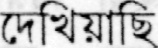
দেখিয়াছি
